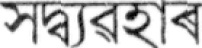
সদ্ব্যৱহাৰ
